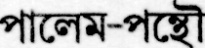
পালেম-পন্থৌ
